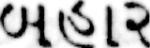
બહાર
